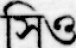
সিও
